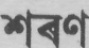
শৰণ
